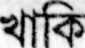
খাকি
